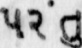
પરંતુ
